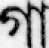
গা
